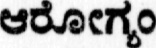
ಆರೋಗ್ಯಂ
